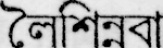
লৈশিন্নবা
